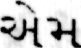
એમ
